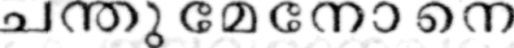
ചന്തുമേനോനെ
